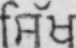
ਸਿੱਖ
